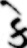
કે
